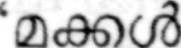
‘മക്കള്‍
